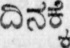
ದಿನಕ್ಕೆ
